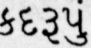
કદરૂપું
